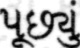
પૂછ્યું
